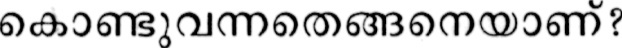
കൊണ്ടുവന്നതെങ്ങനെയാണ്?
